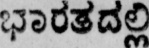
ಭಾರತದಲ್ಲಿ
